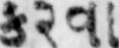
કરવા
